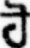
ਹੋ
